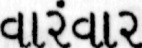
વારંવાર
